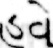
હવે
